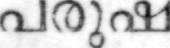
പരുഷ
